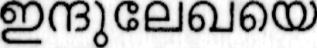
ഇന്ദുലേഖയെ
